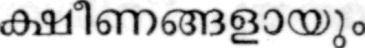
ക്ഷീണങ്ങളായും
